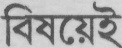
বিষয়েই
